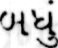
બધું
